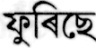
ফুৰিছে
